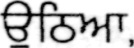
ਉਠਿਆ,
